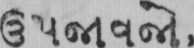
ઉપજાવજો,
